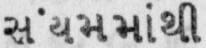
સંયમમાંથી
